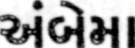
અંબેમા
